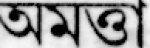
অমত্তা
